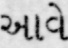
આવે
